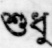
শুধু
